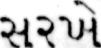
સરખે
